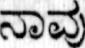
ನಾವು
